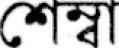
শেম্বা
